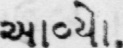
આવ્યો.
